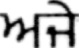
ਅਜੇ
